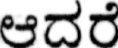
ಆದರೆ
